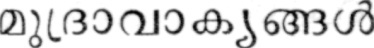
മുദ്രാവാക്യങ്ങള്‍
